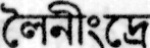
লৈনীংদ্রে
